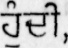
ਹੁੰਦੀ,
